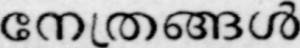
നേത്രങ്ങള്‍
